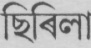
ছিৰিলা
